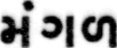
મંગળ
